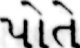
પોતે
